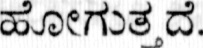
ಹೋಗುತ್ತದೆ.
